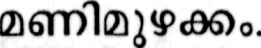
മണിമുഴക്കം.
